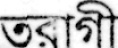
তরাগী
